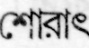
শোরাৎ
